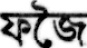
ফজৈ
